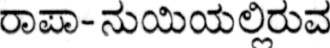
ರಾಪಾ-ನುಯಿಯಲ್ಲಿರುವ
